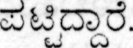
ಪಟ್ಟಿದ್ದಾರೆ.
